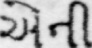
એની
